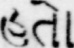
હતો
